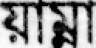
য়াম্না
